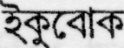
ইকুবোক
